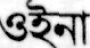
ওইনা
